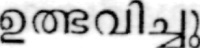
ഉത്ഭവിച്ചു
